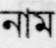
নাম
